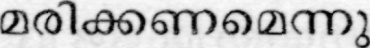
മരിക്കണമെന്നു
